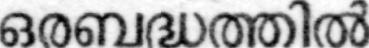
ഒരബദ്ധത്തില്‍
